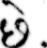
છે.
